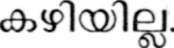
കഴിയില്ല.
